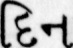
દિન
